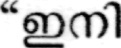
“ഇനി
